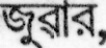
জুৱার,
